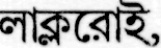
লাক্লরোই,
